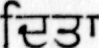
ਦਿਤਾ
